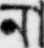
না
